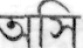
অসি
